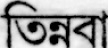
তিন্নবা
